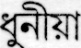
ধুনীয়া
